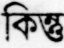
কিন্তু
